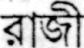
রাজী
